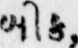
બીક,
